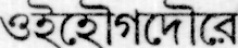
ওইহৌগদৌরে
